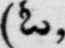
(ಒ,
